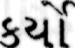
કર્યો
